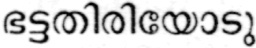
ഭട്ടതിരിയോടു
